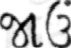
જાઉં
